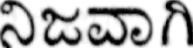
ನಿಜವಾಗಿ
